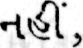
નહીં,
